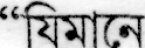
"যিমানে
